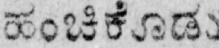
ಹಂಚಿಕೊಡು
